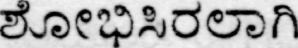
ಶೋಭಿಸಿರಲಾಗಿ
